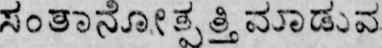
ಸಂತಾನೋತ್ಪತ್ತಿಮಾಡುವ
